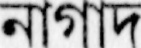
নাগাদ
